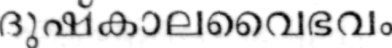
ദുഷ്കാലവൈഭവം
